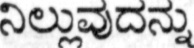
ನಿಲ್ಲುವುದನ್ನು
